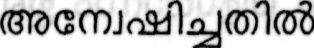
അന്വേഷിച്ചതില്‍
